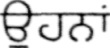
ਉਹਨਾਂ
